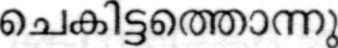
ചെകിട്ടത്തൊന്നു
